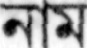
নাম
